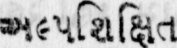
અલ્પશિક્ષિત
